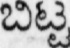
ಬಿಟ್ಟ
